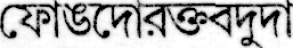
ফোঙদোরক্তবদুদা
